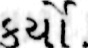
કર્યો.
